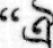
“ঐ
